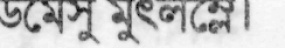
খুৎকন-পাঙ্গনবা,
